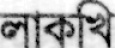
লাকখি
